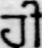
ਹੀ
